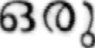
ഒരു
